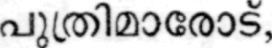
പുത്രിമാരോട്,
